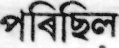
পৰিছিল
